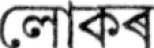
লোকৰ
